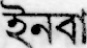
ইনবা
